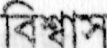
বিশ্বাস
